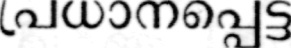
പ്രധാനപ്പെട്ട
